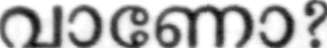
വാണോ?
